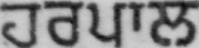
ਹਰਪਾਲ
